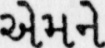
એમને
